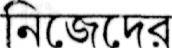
নিজেদের
